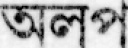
অলপ
